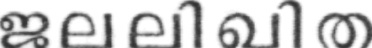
ജലലിഖിത
